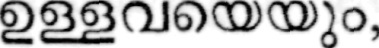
ഉള്ളവയെയും,
